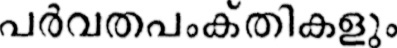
പര്‍വതപംക്തികളും
